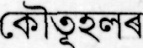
কৌতূহলৰ
